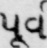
પૂર્વ
